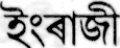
ইংৰাজী
